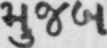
મુજબ
